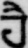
ਹੈ
